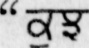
''ਕੁਝ
